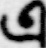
এ
